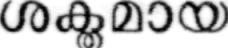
ശക്തമായ
